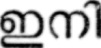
ഇനി
